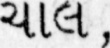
ચાલ,
